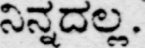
ನಿನ್ನದಲ್ಲ.
